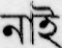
নাই
